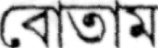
বোতাম
